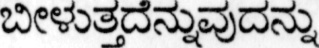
ಬೀಳುತ್ತದೆನ್ನುವುದನ್ನು
